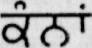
ਕੰਨਾਂ
